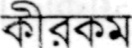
কীরকম
